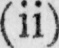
(ii)
